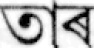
তাৰ
